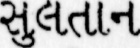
સુલતાન
